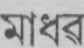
মাধৱ
